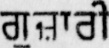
ਗੁਜ਼ਾਰੀ
